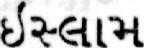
ઇસ્લામ
